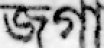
জগা
